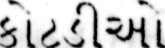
કોટડીઓ
